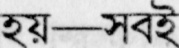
হয়-সবই
